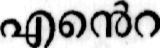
എന്റെ
